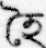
হৈ
